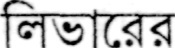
লিভারের
